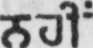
ਨਹੀਂ
